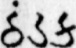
ઠંડક
